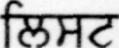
ਲਿਸਟ
